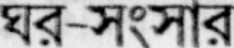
ঘর-সংসার
